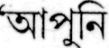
'আপুনি
